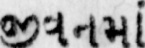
જીવનમાં
